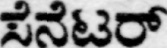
ಸೆನೆಟರ್
